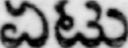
ಏಟು
